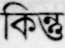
কিন্তু
